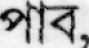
পাব,
